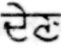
ਦੇਣ
